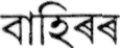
বাহিৰৰ
